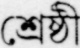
শ্রেষ্ঠী
